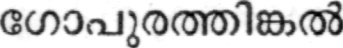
ഗോപുരത്തിങ്കല്‍
